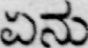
ಏನು
